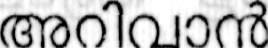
അറിവാന്‍
